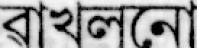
ৱাখলনো
